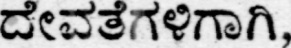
ದೇವತೆಗಳಿಗಾಗಿ,
